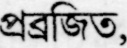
প্রব্রজিত,
